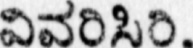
ವಿವರಿಸಿರಿ.
